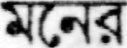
মনের
